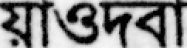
য়াওদবা
